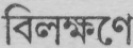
বিলক্ষণে
